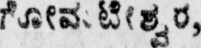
ಗೋಮಟೇಶ್ವರ,
